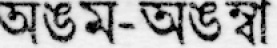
অঙম-অঙম্বা
